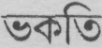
ভকতি
